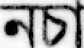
নচা
